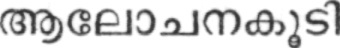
ആലോചനകൂടി
